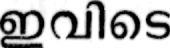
ഇവിടെ
